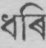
ধৰি
